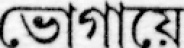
ভোগায়ে
